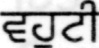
ਵਹੁਟੀ
